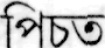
পিচত
